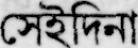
সেইদিনা
